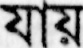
যায়
